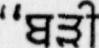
''ਬੜੀ
